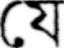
যে
